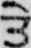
ਤੇ
